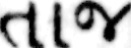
તાજ
